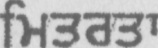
ਮਿਤਰਤਾ
